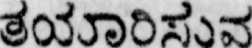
ತಯಾರಿಸುವ
